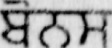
ਬੋਨਸ
